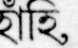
হাঁহি,
